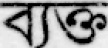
ব্যক্ত
